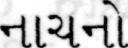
નાચનો
